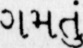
ગમતું
